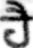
ਹੈ
